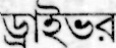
ড্রাইভর
